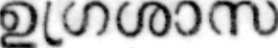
ഉഗ്രശാസ
